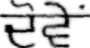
ਦੋਵੇਂ
